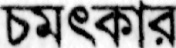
চমৎকার
